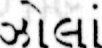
ઝોલા
